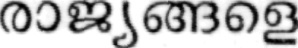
രാജ്യങ്ങളെ
